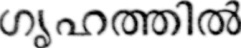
ഗൃഹത്തില്‍
